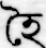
হৈ
